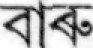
বাৰু
